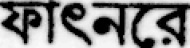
ফাৎনরে
